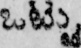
ಒಟ್ಟು
